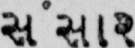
સંસાર
